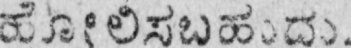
ಹೋಲಿಸಬಹುದು.
